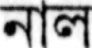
নাল
